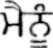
ਮੈਨੂੰ
